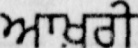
ਆਖ਼ਰੀ
